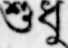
শুধু
